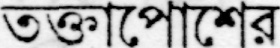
তক্তাপোশের
